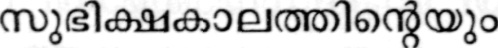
സുഭിക്ഷകാലത്തിന്റെയും
